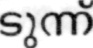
ടുന്ന്
